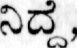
ನಿದ್ದೆ,
